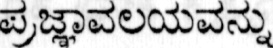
ಪ್ರಜ್ಞಾವಲಯವನ್ನು
